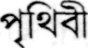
পৃথিবী
